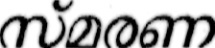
സ്മരണ
